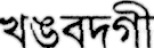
খঙবদগী
